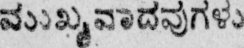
ಮುಖ್ಯವಾದವುಗಳು
